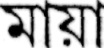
মায়া
